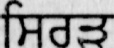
ਸਿਰੜ
